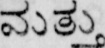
ಮತ್ತು
